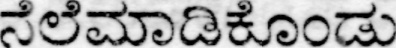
ನೆಲೆಮಾಡಿಕೊಂಡು
